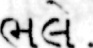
ભલે.
